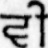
ਵੀ
